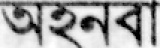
অহনবা
